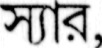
স্যার,
